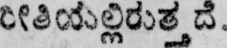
ರೀತಿಯಲ್ಲಿರುತ್ತದೆ.
